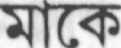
মাকে
